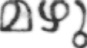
മഴു
